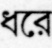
ধরে
